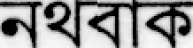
নথবাক
